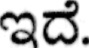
ಇದೆ.
